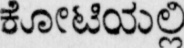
ಕೋಟಿಯಲ್ಲಿ
